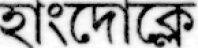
হাংদোক্লে
